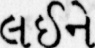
લઈને
